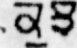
ਕੁਝ
